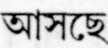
আসছে
